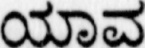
ಯಾವ
